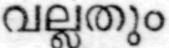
വല്ലതും
